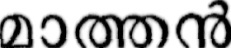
മാത്തന്‍
